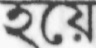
হয়ে
